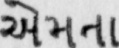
એમના
